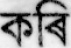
কৰি
